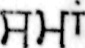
ਸਮਾਂ
